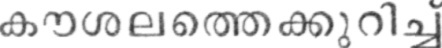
കൌശലത്തെക്കുറിച്ച്
